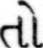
તો
